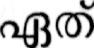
ഏത്
